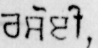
ਰਸੋਈ,
